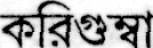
করিগুম্বা
